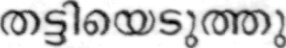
തട്ടിയെടുത്തു
